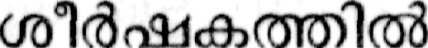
ശീര്‍ഷകത്തില്‍
